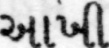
આખી
